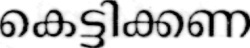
കെട്ടിക്കണ
